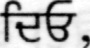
ਦਿਓ,
